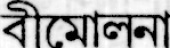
বীমোলনা
